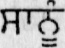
ਸਾਨੂੰ
